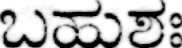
ಬಹುಶಃ
